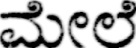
ಮೇಲೆ
